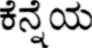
ಕೆನ್ನೆಯ
